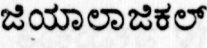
ಜಿಯಾಲಾಜಿಕಲ್
